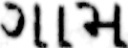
ગામ
